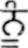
ਨੂੰ
